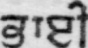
ਭਾਈ
